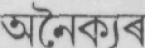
অনৈক্যৰ
